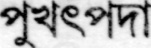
পুখৎপদা
